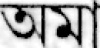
অমা
